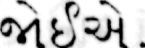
જોઈએ.
